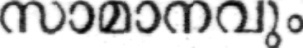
സാമാനവും
